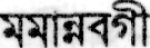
মমান্নবগী
